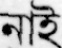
নাই
